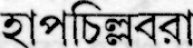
হাপচিল্লরবা
